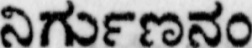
ನಿರ್ಗುಣನಂ
